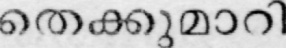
തെക്കുമാറി
